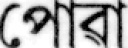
পোৱা
